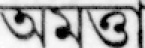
অমত্তা
